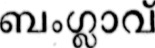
ബംഗ്ലാവ്
